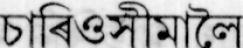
চাৰিওসীমালৈ
